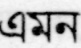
এমন
